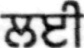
ਲਈ
